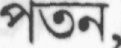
পতন,
